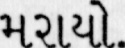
મરાયો.
